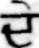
ਦੇ
